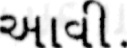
આવી.
